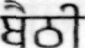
ਬੈਠੀ
